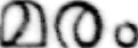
മരം
